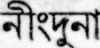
নীংদুনা
